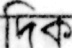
দিক
